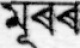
মূৰৰ
